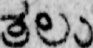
ತಲು
